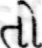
તો
